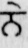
ਨੇ
